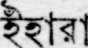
ইঁহারা
